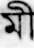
মী
